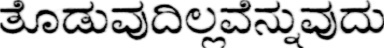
ತೊಡುವುದಿಲ್ಲವೆನ್ನುವುದು
